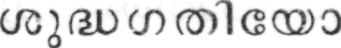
ശുദ്ധഗതിയോ
